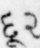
દૂર
